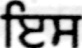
ਇਸ
